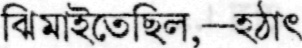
ঝিমাইতেছিল,—হঠাৎ
